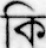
কি
